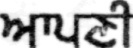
ਆਪਣੀ
